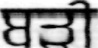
ਬੜੀ
